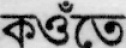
কওঁতে
